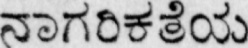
ನಾಗರಿಕತೆಯ
